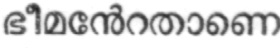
ഭീമന്റേതാണെ
